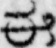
ಈ
